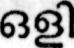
ഒളി
